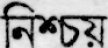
নিশ্চয়
